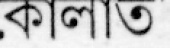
কোলাত
